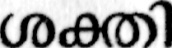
ശക്തി
